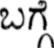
ಬಗ್ಗೆ
